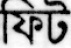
ফিট
